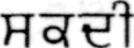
ਸਕਦੀ
